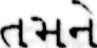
તમને
